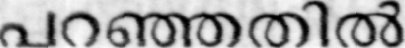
പറഞ്ഞതില്‍
